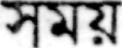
সময়
